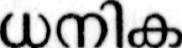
ധനിക
